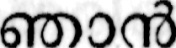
ഞാന്‍
